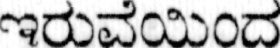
ಇರುವೆಯಿಂದ
